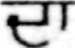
ਦਾ
